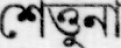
শেত্তুনা
